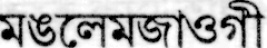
মঙলেমজাওগী
